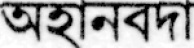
অহানবদা
